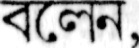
বলেন,
